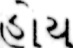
હોય
